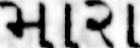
મારા
